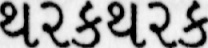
થરકથરક
